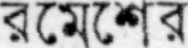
রমেশের
